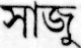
সাজু
